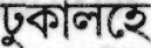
ঢুকালহে
